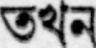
তখন
